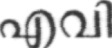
എവി
